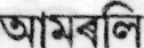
আমৰলি
